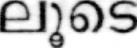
ലൂടെ
